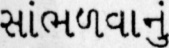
સાંભળવાનું
